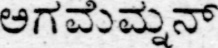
ಅಗಮೆಮ್ನನ್
